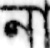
না
